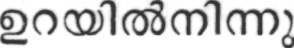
ഉറയില്‍നിന്നു
